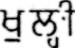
ਖੁਲ੍ਹੀ
